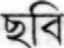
ছবি
